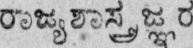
ರಾಜ್ಯಶಾಸ್ತ್ರಜ್ಞರ
